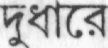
দুধারে
